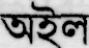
অইল
